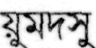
য়ুমদসু
